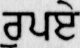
ਰੁਪਏ
